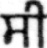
ਸੀ
